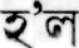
হ'ল
